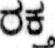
ರಕ್ತ
